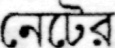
নেটের
